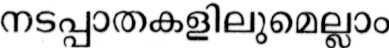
നടപ്പാതകളിലുമെല്ലാം
